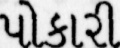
પોકારી
